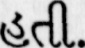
હતી.
